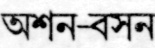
অশন-বসন
